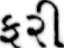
ફરી
